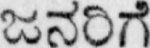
ಜನರಿಗೆ
